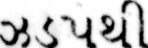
ઝડપથી
